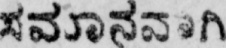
ಸಮಾನವಾಗಿ
